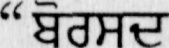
''ਬੋਰਸਦ
